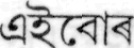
এইবোৰ
